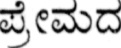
ಪ್ರೇಮದ
